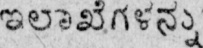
ಇಲಾಖೆಗಳನ್ನು
